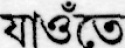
যাওঁতে
